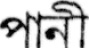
পানী
